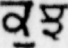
ਕੁਝ
